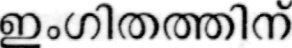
ഇംഗിതത്തിന്
